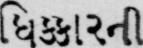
ધિક્કારની
